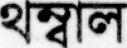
থম্বাল
